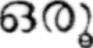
ഒരൂ
